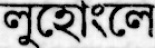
লুহোংলে
